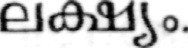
ലക്ഷ്യം.
